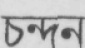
চন্দন
